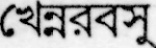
খেন্নরবসূ
